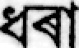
ধৰা
